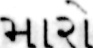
મારો
